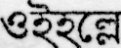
ওইহল্লে
